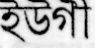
ইউগী
